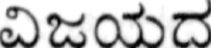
ವಿಜಯದ
